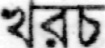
খরচ
